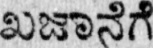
ಖಜಾನೆಗೆ
